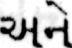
અને
